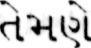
તેમણે
